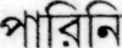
পারিনি
